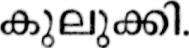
കുലുക്കി.
